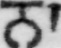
ਨਾ
